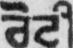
ਰੋਟੀ
